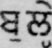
ਬੁਲ੍ਹੇ
